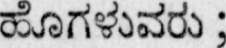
ಹೊಗಳುವರು;
